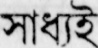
সাধ্যই
